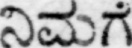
ನಿಮಗೆ
